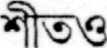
শীতও
